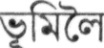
ভূমিলৈ
